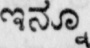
ಇನ್ನೂ
